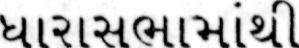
ધારાસભામાંથી
